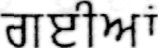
ਗਈਆਂ
